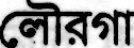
লৌরগা
